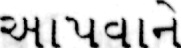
આપવાને
